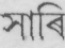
সাৰি
